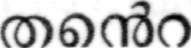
തന്റെ
